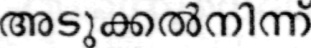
അടുക്കല്‍നിന്ന്
